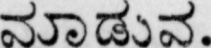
ಮಾಡುವ.
